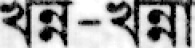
খন্ন-খন্না
